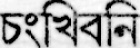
চংখিবনি
